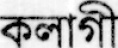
কলাগী
